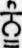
ਨੂੰ
